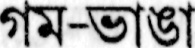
গম-ভাঙা
